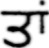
ਤਾਂ
